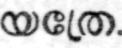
യത്രേ.
